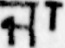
ਜਾ
